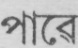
পাৱে
